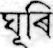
ঘূৰি
